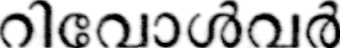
റിവോള്‍വര്‍
